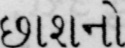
છાશનો
